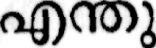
എന്തു
